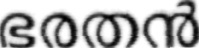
ഭരതന്‍
